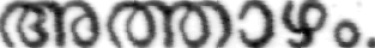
അത്താഴം.
